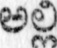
ಅಲ್ಲಿ
